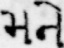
મને
